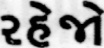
રહેજો
